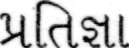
પ્રતિજ્ઞા
